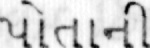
પોતાની
